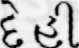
દેહી
